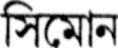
সিমোন
